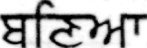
ਬਣਿਆ
